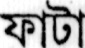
ফাটা
